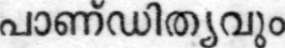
പാണ്ഡിത്യവും
